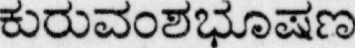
ಕುರುವಂಶಭೂಷಣ
